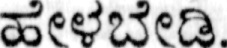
ಹೇಳಬೇಡಿ.
